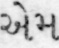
એમ
